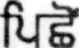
ਪਿਛੋਂ
